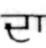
ਦਾ
